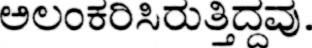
ಅಲಂಕರಿಸಿರುತ್ತಿದ್ದವು.
